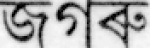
জগৰু
